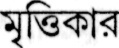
মৃত্তিকার
